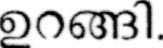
ഉറങ്ങി.
